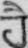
ਹੈ
